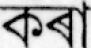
কৰা
